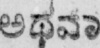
ಅಥವಾ
